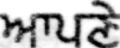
ਆਪਣੇ
